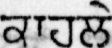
ਕਾਹਲੇ
